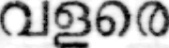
വളരെ
